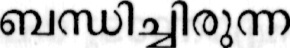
ബന്ധിച്ചിരുന്ന
